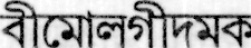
বীমোলগীদমক
